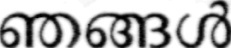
ഞങ്ങള്‍
